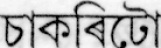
চাকৰিটো
